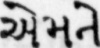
એમને
